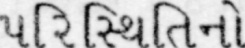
પરિસ્થિતિનો
